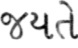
જયતે
